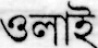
ওলাই
